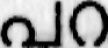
പറ
